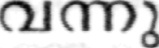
വന്നു
